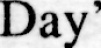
Day’
